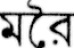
মরৈ
